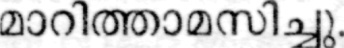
മാറിത്താമസിച്ചു.
